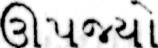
ઊપજ્યો
